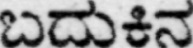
ಬದುಕಿನ
